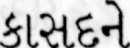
કાસદને
